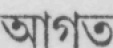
আগত
